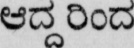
ಆದ್ದರಿಂದ
